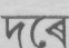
দৰে
